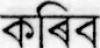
কৰিব
